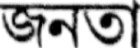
জনতা
